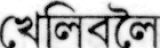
খেলিবলৈ
